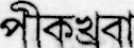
পীকখ্রবা
